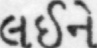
લઈને
